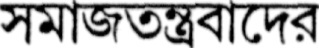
সমাজতন্ত্রবাদের
